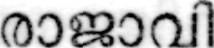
രാജാവി
